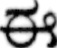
ಈ
